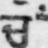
ਚੋਂ
